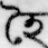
হৈ
